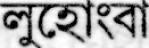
লুহোংবা
